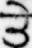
ਤੇ
